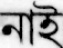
নাই
